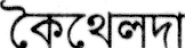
কৈথেলদা
